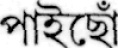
পাইছোঁ
